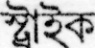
স্ট্রাইক
